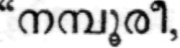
“നമ്പൂരീ,
